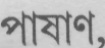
পাষাণ,
